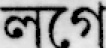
লগে
